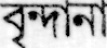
বৃন্দানা
